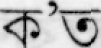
ক'ত
